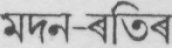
মদন-ৰতিৰ
